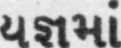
યજ્ઞમાં
